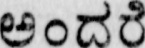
ಅಂದರೆ
